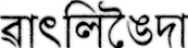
ৱাৎলিঙৈদা
